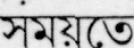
সময়তে
